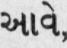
આવે,
